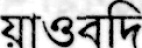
য়াওবদি
